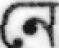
নে
